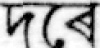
দৰে
